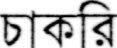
চাকরি
